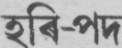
হৰি-পদ
